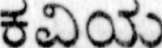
ಕವಿಯ
